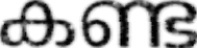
കണ്ട
